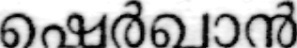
ഷെര്‍ഖാന്‍
